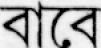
বাবে
